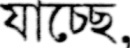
যাচ্ছে,
